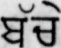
ਬੱਚੇ
